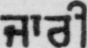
ਜਾਰੀ
